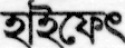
হাইফেৎ
